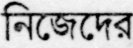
নিজেদের
